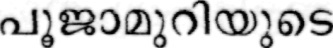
പൂജാമുറിയുടെ
